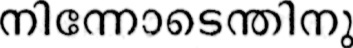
നിന്നോടെന്തിനു
